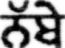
ਨੱਬੇ
